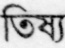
তিষ্য
